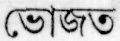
ভোজত
